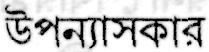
উপন্যাসকার
